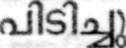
പിടിച്ചു
